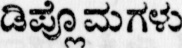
ಡಿಪ್ಲೊಮಗಳು
